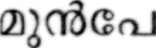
മുന്‍പേ
